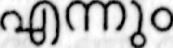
എന്നും
